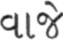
વાજે
